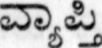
ವ್ಯಾಪ್ತಿ
